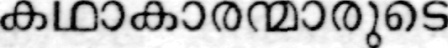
കഥാകാരന്മാരുടെ
